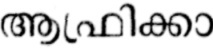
ആഫ്രിക്കാ
